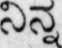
ನಿನ್ನ
